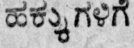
ಹಕ್ಕುಗಳಿಗೆ
